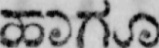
ಹಾಗೂ
